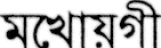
মখোয়গী
